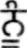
ਨੂੰ
